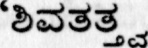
‘ಶಿವತತ್ತ್ವ
